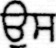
ਉਸ
